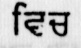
ਵਿਚ
